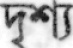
দৃশ্য
